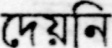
দেয়নি
